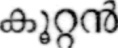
കൂറ്റന്‍
